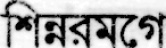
শিন্নরমগে
